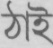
ঠাই
